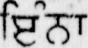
ਇੰਨਾ
